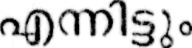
എന്നിട്ടും
